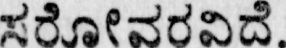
ಸರೋವರವಿದೆ.
